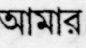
আমার
